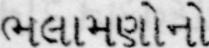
ભલામણોનો
